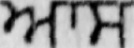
ਆਸ
